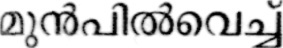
മുന്‍പില്‍വെച്ച്
